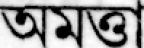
অমত্তা
